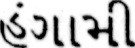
હંગામી
